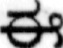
ಈ
